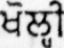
ਖੋਲ੍ਹੀ
